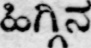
ಹಿಗ್ಗಿನ
